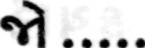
જો.......
